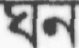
ঘন
